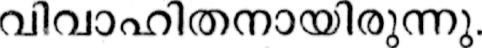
വിവാഹിതനായിരുന്നു.
